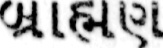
બ્રાહ્મણ
